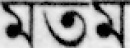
মতম
